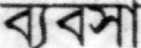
ব্যবসা
